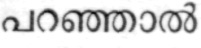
പറഞ്ഞാല്‍
